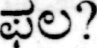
ಫಲ?
